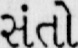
સંતો
